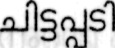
ചിട്ടപ്പടി
